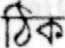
ঠিক
